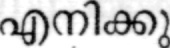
എനിക്കു
